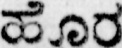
ಹೊರ
